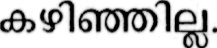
കഴിഞ്ഞില്ല.
